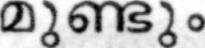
മുണ്ടും
